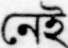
নেই
